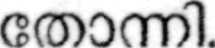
തോന്നി.
